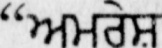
''ਅਮਰੇਸ਼
